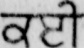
ਕਈ
